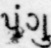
પંગુ
